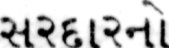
સરદારનો
